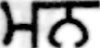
ਮਨ
